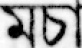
মচা
